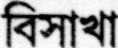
বিসাখা
